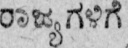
ರಾಜ್ಯಗಳಿಗೆ
